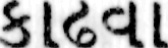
કાઢવા
